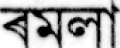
ৰমলা
